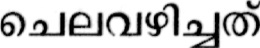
ചെലവഴിച്ചത്
